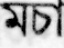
মচা
